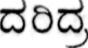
ದರಿದ್ರ
